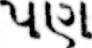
પણ
